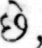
છે,
